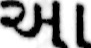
આ
